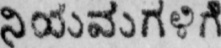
ನಿಯಮಗಳಿಗೆ
